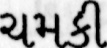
ચમકી
